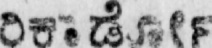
ರಿಕಾರ್ಡೋ
